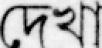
দেখা
